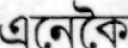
এনেকৈ
